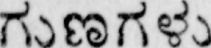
ಗುಣಗಳು
